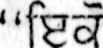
''ਇਕੋ
